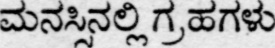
ಮನಸ್ಸಿನಲ್ಲಿಗ್ರಹಗಳು
